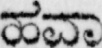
ಹವಾ
